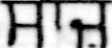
ਸਾਜ਼
